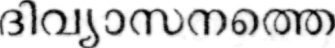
ദിവ്യാസനത്തെ
